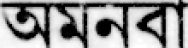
অমনবা
